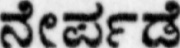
ನೇರ್ಪಡೆ
